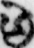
છે
